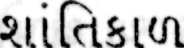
શાંતિકાળ
